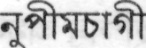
নুপীমচাগী
